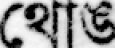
থোঙ
